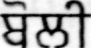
ਬੋਲੀ
